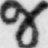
જ
